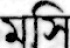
মসি
